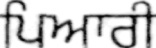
ਪਿਆਰੀ
